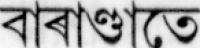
বাৰাণ্ডাতে
